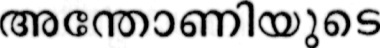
അന്തോണിയുടെ
